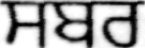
ਸਬਰ
